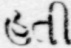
હતી
